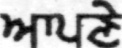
ਆਪਣੇ
